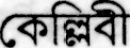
কেল্লিবী
